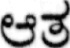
ಆತ
